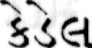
કેડેલ
